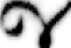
જ
